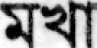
মখা
